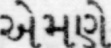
એમણે
